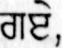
ਗਏ,
